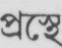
প্রস্থে
